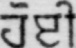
ਹੋਈ
